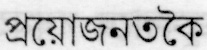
প্রয়োজনতকৈ
